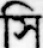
সি
